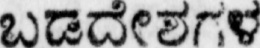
ಬಡದೇಶಗಳ
